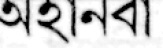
অহানবা
